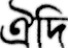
ঐদি
